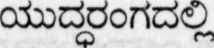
ಯುದ್ಧರಂಗದಲ್ಲಿ
